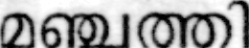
മഞ്ചത്തി
